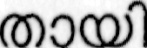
തായി
